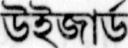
উইজার্ড
